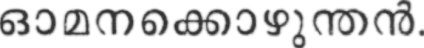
ഓമനക്കൊഴുന്തന്‍.
